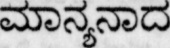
ಮಾನ್ಯನಾದ
